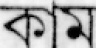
কাম
